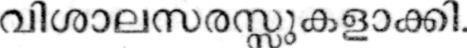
വിശാലസരസ്സുകളാക്കി.
